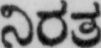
ನಿರತ
